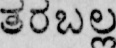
ತರಬಲ್ಲ
